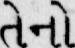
તેનો
